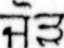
ਜੋੜ
